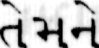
તેમને
